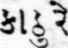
કાઠુરે
